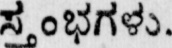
ಸ್ತಂಭಗಳು.
